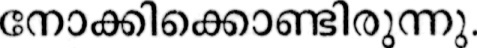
നോക്കിക്കൊണ്ടിരുന്നു.
